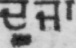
ਦੂਜਾ
